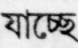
যাচ্ছে
